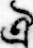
ঐ
